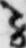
કે
